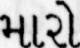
મારો
